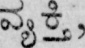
ವ್ಯಕ್ತಿ,
